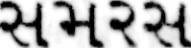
સમરસ
